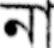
না
